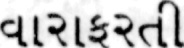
વારાફરતી
